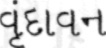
વૃંદાવન
